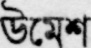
উমেশ
